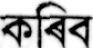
কৰিব
